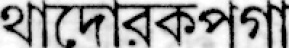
থাদোরকপগা
